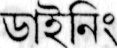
ডাইনিং
